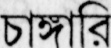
চাঙ্গারি
